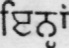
ਇਨ੍ਹਾਂ
